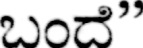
ಬಂದೆ"
